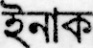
ইনাক
